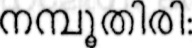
നമ്പൂതിരി:
